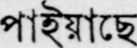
পাইয়াছে
